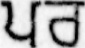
ਪਰ
